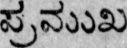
ಪ್ರಮುಖ
